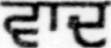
ਵਾਦ
